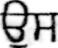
ਉਸ
